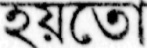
হয়তো
